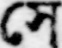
সে
